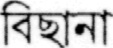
বিছানা
